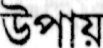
উপায়
